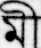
মী
